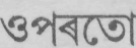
ওপৰতো
